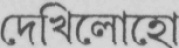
দেখিলোহো
